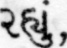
રહ્યું,
